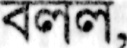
বলল,
